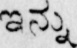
ಇನ್ನು
